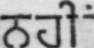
ਨਹੀਂ
